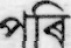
পৰি
